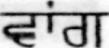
ਵਾਂਗ
